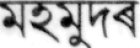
মহমুদৰ
